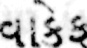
વાકેફ
